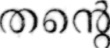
തന്റെ
